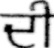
ਦੀ
